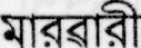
মারৱারী
